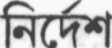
নির্দেশ
